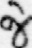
જે
